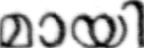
മായി
